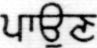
ਪਾਉਣ
